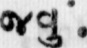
જવું.
